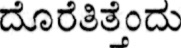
ದೊರೆತಿತ್ತೆಂದು
